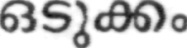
ഒടുക്കം
